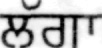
ਲੱਗਾ
